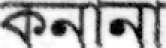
কনানা
